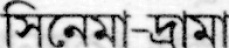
সিনেমা-দ্রামা
